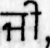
ਜੀ,
